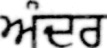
ਅੰਦਰ
